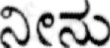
ನೀನು
